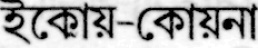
ইকোয়-কোয়না
